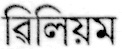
ৱিলিয়ম
